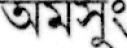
অমসুং
